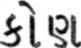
કોણ
